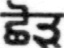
ਛੋੜ
